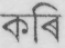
কৰি
